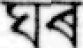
ঘৰ
